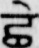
ਛੇ
